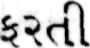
ફરતી
